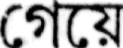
গেয়ে
